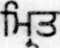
ਮ੍ਰਿਤ
